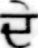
ਦੇ
